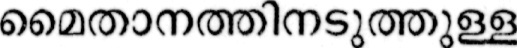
മൈതാനത്തിനടുത്തുള്ള
